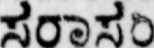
ಸರಾಸರಿ
